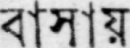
বাসায়
